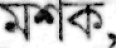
মশক,
